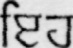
ਇਹ
